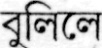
বুলিলে
